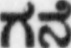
ಗನೆ
